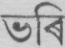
ভৰি
